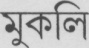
মুকলি
